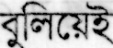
বুলিয়েই
